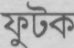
ফুটক
